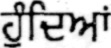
ਹੁੰਦਿਆਂ
